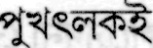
পুখৎলকই
